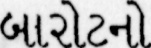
બારોટનો
